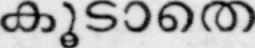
കൂടാതെ
